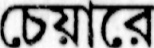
চেয়ারে
